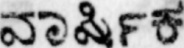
ವಾರ್ಷಿಕ
